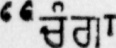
''ਚੰਗਾ
